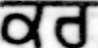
ਕਰ
